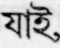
যাই,
